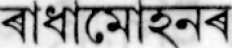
ৰাধামোহনৰ
